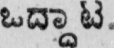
ಒದ್ದಾಟ.
